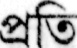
প্রতি
